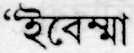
“ইবেম্মা
